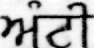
ਅੰਟੀ
